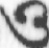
ও
